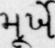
મૂર્ખે
